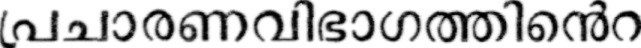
പ്രചാരണവിഭാഗത്തിന്റെ
